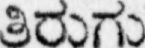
ತಿರುಗು
